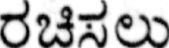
ರಚಿಸಲು
